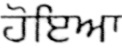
ਹੋਇਆ
